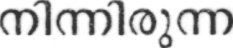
നിന്നിരുന്ന
